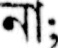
না;
